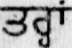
ਤਰ੍ਹਾਂ
